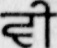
ਵੀ
